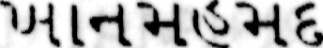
ખાનમહમદ
